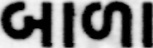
બાળા
